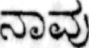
ನಾವು
